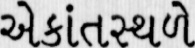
એકાંતસ્થળે
